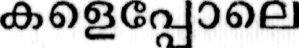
കളെപ്പോലെ
